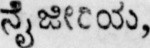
ನೈಜೀರಿಯ,
